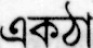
একঠা
